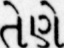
તેણે
